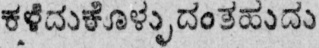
ಕಳೆದುಕೊಳ್ಳುದಂತಹುದು
